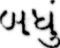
બધું
